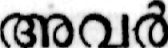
അവര്‍
